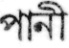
পানী
